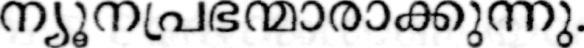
ന്യൂനപ്രഭന്മാരാക്കുന്നു.
